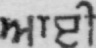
ਆਈ
